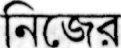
নিজের
